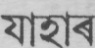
যাহাৰ
